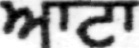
ਆਟਾ
